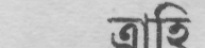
ত্ৰাহি
